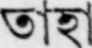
তাহা
